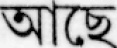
আছে
